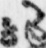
કહે
